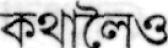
কথালৈও
